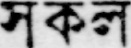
সকল
